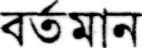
বর্তমান
